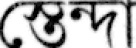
স্তেন্দা
